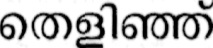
തെളിഞ്ഞ്
